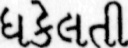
ધકેલતી
